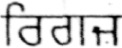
ਰਿਗਜ਼
